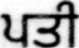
ਪਤੀ
